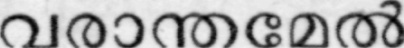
വരാന്തമേല്‍
